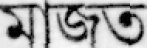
মাজত
